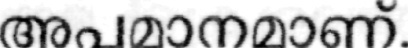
അപമാനമാണ്.
